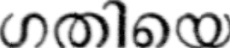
ഗതിയെ
